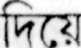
দিয়ে
